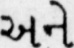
અને
